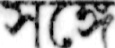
সঙ্গে
